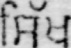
ਸਿੱਖ
